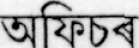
অফিচৰ
